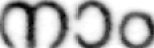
നാം
